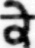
ਕੇ
